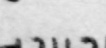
અમુક
